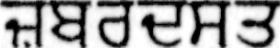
ਜ਼ਬਰਦਸਤ
